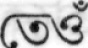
তেওঁ
